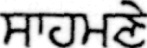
ਸਾਹਮਣੇ
